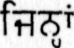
ਜਿਨ੍ਹਾਂ
